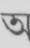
অ
